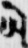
બે
